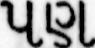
પણ
